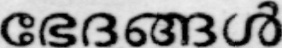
ഭേദങ്ങള്‍
